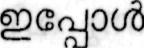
ഇപ്പോള്‍
